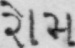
રોમ
